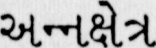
અન્નક્ષેત્ર
